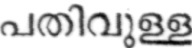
പതിവുള്ള
